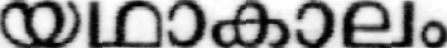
യഥാകാലം
